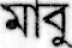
মাবু
